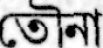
তৌনা
